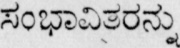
ಸಂಭಾವಿತರನ್ನು
